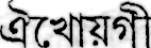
ঐখোয়গী
